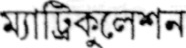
ম্যাট্রিকুলেশন
